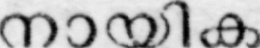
നായിക
